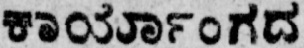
ಕಾರ್ಯಾಂಗದ
